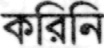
করিনি
